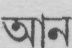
আন
